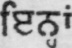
ਇਨ੍ਹਾਂ
